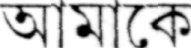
আমাকে
